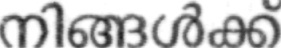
നിങ്ങള്‍ക്ക്
